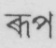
ৰূপ
